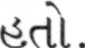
હતો.
